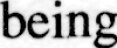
being
